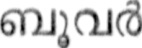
ബൂവര്‍
